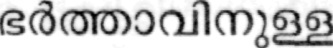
ഭര്‍ത്താവിനുള്ള
